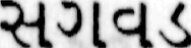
સગવડ
